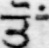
ਤੋਂ
